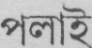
পলাই
